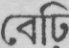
বেঢ়ি
